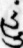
હું
